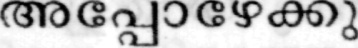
അപ്പോഴേക്കു
